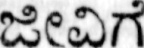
ಜೀವಿಗೆ
